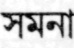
সমনা
